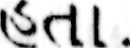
હતા.
